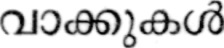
വാക്കുകള്‍
